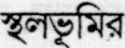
স্থলভূমির
